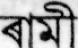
ৰামী
